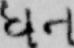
ધન
